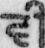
ਵੀ
